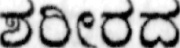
ಶರೀರದ
